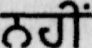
ਨਹੀਂ
